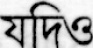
যদিও
